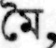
মৈ,
